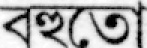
বহুতো
